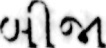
બીજા
